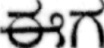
ಈಗ
